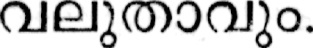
വലുതാവും.
